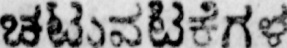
ಚಟುವಟಿಕೆಗಳ
